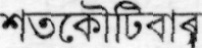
শতকৌটিবাৰ
